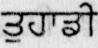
ਤੁਹਾਡੀ
